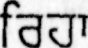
ਰਿਹਾ
